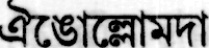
ঐঙোল্লোমদা
